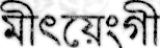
মীৎয়েংগী
